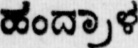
ಹಂದ್ರಾಳ
